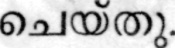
ചെയ്തു.
